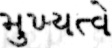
મુખ્યત્વે
